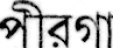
পীরগা
